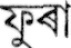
ফুৰা
